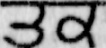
ਤਕ
